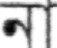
না
